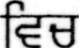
ਵਿਚ
